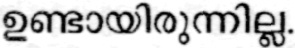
ഉണ്ടായിരുന്നില്ല.
